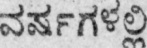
ವರ್ಷಗಳಲ್ಲಿ
